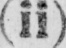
(ii)
